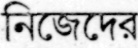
নিজেদের
